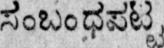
ಸಂಬಂಧಪಟ್ಟ
